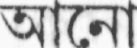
আনো
